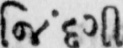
જિંદગી
